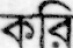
করি
